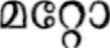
മറ്റോ
